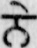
ਨੇ
